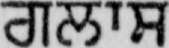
ਗਲਾਸ
